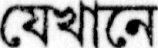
যেখানে
